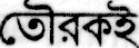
তৌরকই
